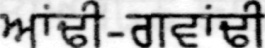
ਆਂਢੀ-ਗਵਾਂਢੀ
